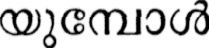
യുമ്പോള്‍
